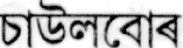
চাউলবোৰ
